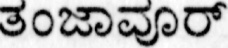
ತಂಜಾವೂರ್
